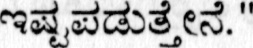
ಇಷ್ಟಪಡುತ್ತೇನೆ.”
